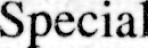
Special
